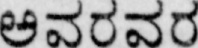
ಅವರವರ
